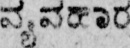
ವ್ಯವಹಾರ
